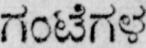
ಗಂಟೆಗಳ
